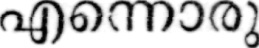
എന്നൊരു
